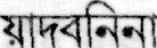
য়াদবনিনা
